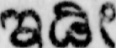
ಇಡೀ
